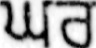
ਘਰ
